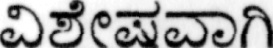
ವಿಶೇಷವಾಗಿ
